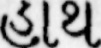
હાથ
